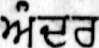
ਅੰਦਰ
